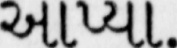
આપ્યા.
